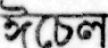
ঈচেল
